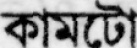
কামটো
